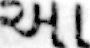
આ
